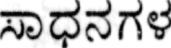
ಸಾಧನಗಳ
